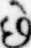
છે
